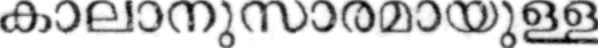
കാലാനുസാരമായുള്ള
